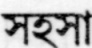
সহসা
